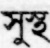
সুস্থ
